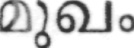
മുഖം
